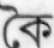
কৈ
